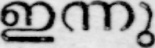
ഇന്നു
